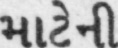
માટેની
